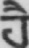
ਹੈ
